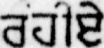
ਰਹੀਏ
